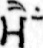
ਮੈਂ
